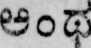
ಅಂಥ
